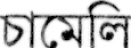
চামেলি
